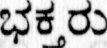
ಭಕ್ತರು
